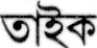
তাইক
